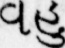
વહુ
